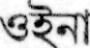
ওইনা
